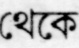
থেকে
